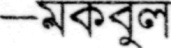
-মকবুল
